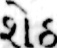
શેઠ
